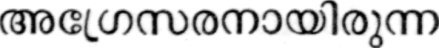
അഗ്രേസരനായിരുന്ന
